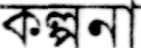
কল্পনা
